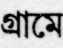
গ্রামে
